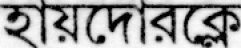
হায়দোরক্লে
